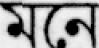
মনে
